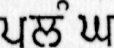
ਪਲੰਘ
